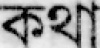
কথা
